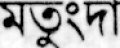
মতুংদা
